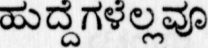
ಹುದ್ದೆಗಳೆಲ್ಲವೂ
